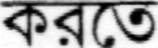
করতে
